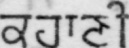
ਕਹਾਣੀ
